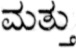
ಮತ್ತು
